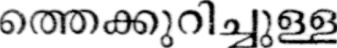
ത്തെക്കുറിച്ചുള്ള
